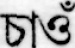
চাওঁ
